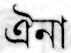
ঐনা
